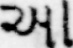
આ
